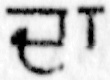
ਦਾ
